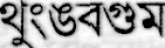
থুংঙবগুম
